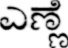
ಎಣ್ಣೆ
